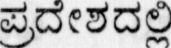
ಪ್ರದೇಶದಲ್ಲಿ
